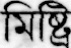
মিষ্ট্রি
